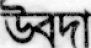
উবদা
